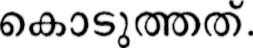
കൊടുത്തത്.
